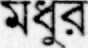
মধুর
